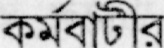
কর্মবাটীর
